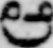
ಆ
